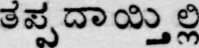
ತಪ್ಪದಾಯ್ತಿಲ್ಲಿ
